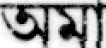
অমা
